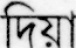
দিয়া
